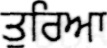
ਤੁਰਿਆ
